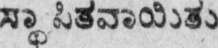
ಸ್ಥಾಪಿತವಾಯಿತು
